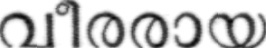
വീരരായ
